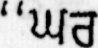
''ਘਰ
